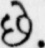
છે.
